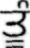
ਤੂੰ
